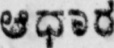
ಆಧಾರ
